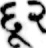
દૂર
